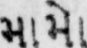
મામો
